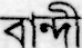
বান্দী
